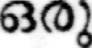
ഒരു
